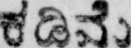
ಕಡಿಮೆ
